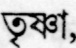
তৃষ্ণা,
